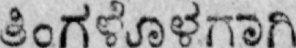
ತಿಂಗಳೊಳಗಾಗಿ
